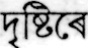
দৃষ্টিৰে
